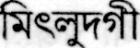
মিৎলুদগী
